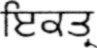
ਇਕਤ੍ਰ
